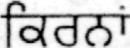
ਕਿਰਨਾਂ
